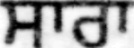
ਸਾਰਾ
